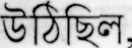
উঠিছিল,
